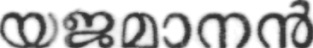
യജമാനന്‍
